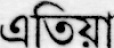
এতিয়া
